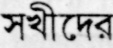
সখীদের
